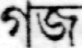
গজ
